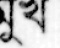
মুখ
